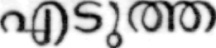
എടുത്ത
